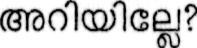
അറിയില്ലേ?
